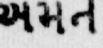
અમને
